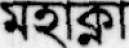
মহাক্না
